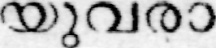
യുവരാ
